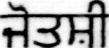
ਜੋਤਸ਼ੀ
